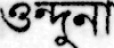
ওন্দুনা
